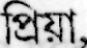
প্রিয়া
